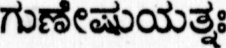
ಗುಣೇಷುಯತ್ನಃ
